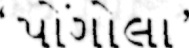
'પોંગોલા'
